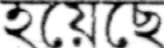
হয়েছে
